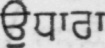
ਉਧਾਰਾ
